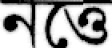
নত্তে
